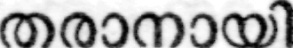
തരാനായി
